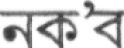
নক'ব
